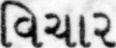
વિચાર
